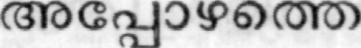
അപ്പോഴത്തെ
